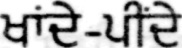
ਖਾਂਦੇ-ਪੀਂਦੇ
